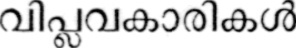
വിപ്ലവകാരികള്‍
